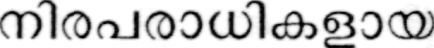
നിരപരാധികളായ
